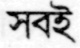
সবই
